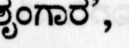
‘ಶೃ೦ಗಾರ’,
